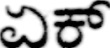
ಏಕ್
